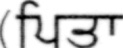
(ਪਿਤਾ
